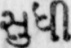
સુધી
